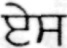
ਏਸ
